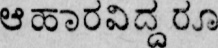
ಆಹಾರವಿದ್ದರೂ
